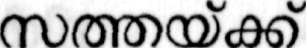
സത്തയ്ക്ക്
